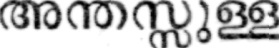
അന്തസ്സുള്ള
